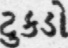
ટુકડો
